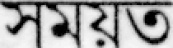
সময়ত
